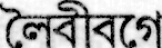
লৈবীবগে
